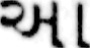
આ
